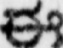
ಈ
